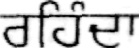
ਰਹਿੰਦਾ
